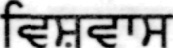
ਵਿਸ਼ਵਾਸ
